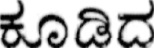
ಕೂಡಿದ
